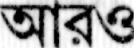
আরও
